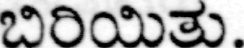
ಬಿರಿಯಿತು.
